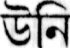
উনি
